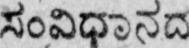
ಸಂವಿಧಾನದ
